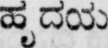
ಹೃದಯ
